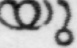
യു
